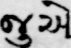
જુએ
